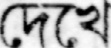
দেখে
